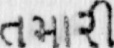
તમારી
